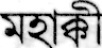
মহাক্কী
